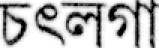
চৎলগা
